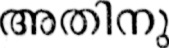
അതിനു
